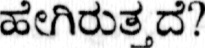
ಹೇಗಿರುತ್ತದೆ?
